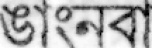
ঙাংনবা
